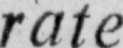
rate
